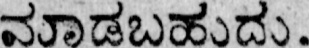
ಮಾಡಬಹುದು.
